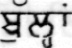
ਬੁੱਲ੍ਹਾਂ
